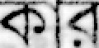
কার
